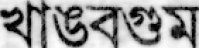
খাঙবগুম
